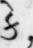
કે,
